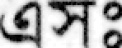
এসঃ
